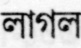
লাগল
